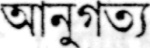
আনুগত্য
